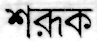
শরূক
